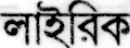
লাইরিক
